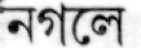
'নগলে
